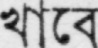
খাবে
